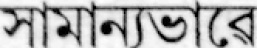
সামান্যভাৱে
